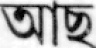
আছ
